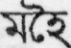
মহৈ
